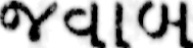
જવાબ
